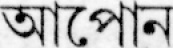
আপোন
